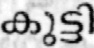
കുട്ടി
